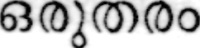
ഒരുതരം
